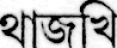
থাজখি
